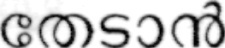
തേടാന്‍
